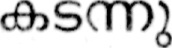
കടന്നു
